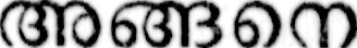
അങ്ങനെ
